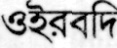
ওইরবদি
